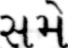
સમે
